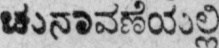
ಚುನಾವಣೆಯಲ್ಲಿ
